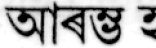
আৰম্ভ
